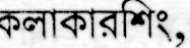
কলাকারশিং,
